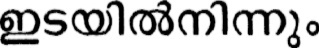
ഇടയില്‍നിന്നും
